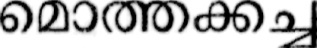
മൊത്തക്കച്ച
